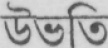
উভতি
